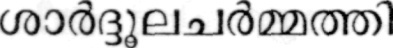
ശാര്‍ദ്ദൂലചര്‍മ്മത്തി
